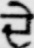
ਦੇ
